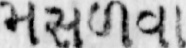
મસળવા
